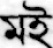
মই
